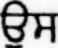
ਉਸ
